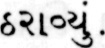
ઠરાવ્યું.
